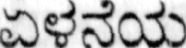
ಏಳನೆಯ
